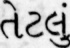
તેટલું
